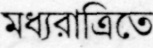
মধ্যরাত্রিতে
